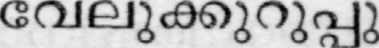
വേലുക്കുറുപ്പു
